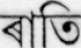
ৰাতি
